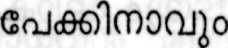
പേക്കിനാവും
